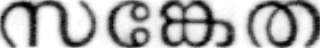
സങ്കേത
